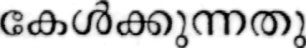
കേള്‍ക്കുന്നതു
